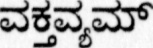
ವಕ್ತವ್ಯಮ್
